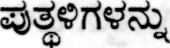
ಪುತ್ಥಳಿಗಳನ್ನು
